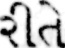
રીતે
